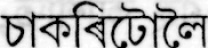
চাকৰিটোলৈ
